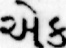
એક
